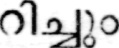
റിച്ചും
